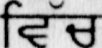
ਵਿੱਚ
